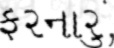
ફરનારું,
